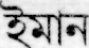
ইমান
